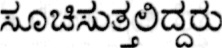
ಸೂಚಿಸುತ್ತಲಿದ್ದರು
